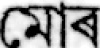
মোৰ
